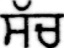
ਸੱਚ
